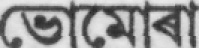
ভোমোৰা
